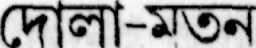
দোলা-মতন
